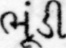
ભૂંડી
